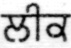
ਲੀਕ
